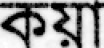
কয়া
